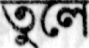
তুলে
